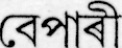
বেপাৰী
